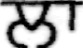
ਲਾ
